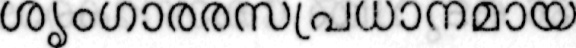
ശൃംഗാരരസപ്രധാനമായ
